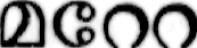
മറ്റേ
